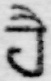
ਹੈ
